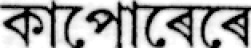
কাপোৰেৰে
